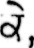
ਕੇ,
